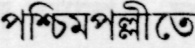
পশ্চিমপল্লীতে
